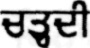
ਚੜ੍ਹਦੀ
